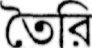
তৈরি
